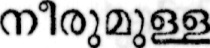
നീരുമുള്ള
